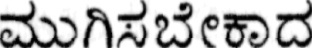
ಮುಗಿಸಬೇಕಾದ
